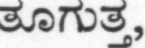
ತೂಗುತ್ತ,
